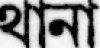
থানা
